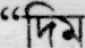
"দিম
